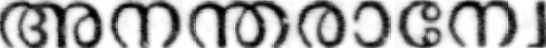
അനന്തരാന്വേ
